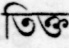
তিক্ত
